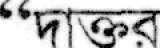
“দাক্তর
